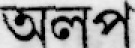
অলপ
